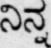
ನಿನ್ನ
